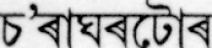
চ'ৰাঘৰটোৰ
